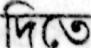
দিতে
